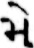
મે
